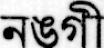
নঙগী
